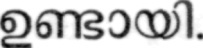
ഉണ്ടായി.
